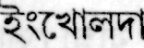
ইংখোলদা
